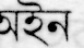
অইন
